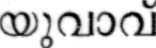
യുവാവ്
